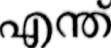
എന്ത്
